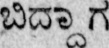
ಬಿದ್ದಾಗ
